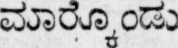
ಮಾರ್‍ಕೊಂಡು
